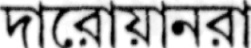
দারোয়ানরা
